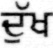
ਦੁੱਖ
